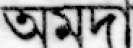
অমদা
